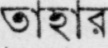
তাহার
